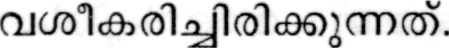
വശീകരിച്ചിരിക്കുന്നത്.
